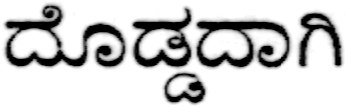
ದೊಡ್ಡದಾಗಿ
